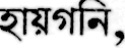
হায়গনি,
